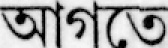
আগতে
